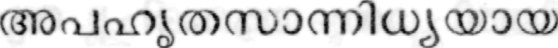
അപഹൃതസാന്നിധ്യയായ
